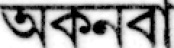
অকনবা
